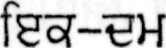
ਇਕ-ਦਮ
